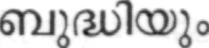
ബുദ്ധിയും
